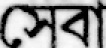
সেবা
